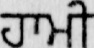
ਹਾਮੀ
